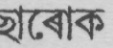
ছাৰোক
